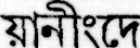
য়ানীংদে
